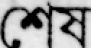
শেষ
